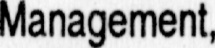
Management,
